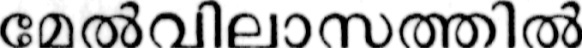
മേല്‍വിലാസത്തില്‍
